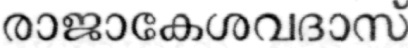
രാജാകേശവദാസ്
